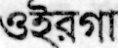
ওইরগা
